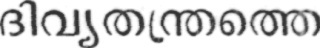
ദിവ്യതന്ത്രത്തെ
